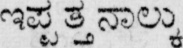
ಇಪ್ಪತ್ತನಾಲ್ಕು
